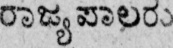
ರಾಜ್ಯಪಾಲರು
